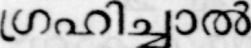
ഗ്രഹിച്ചാല്‍
